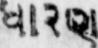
ધારણ
